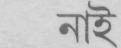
নাই
